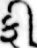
ફી
